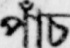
পাঁচ
